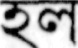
হল
